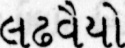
લઢવૈયો
